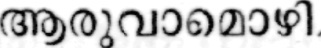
ആരുവാമൊഴി.
